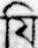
যি
